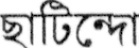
ছাটিন্দো
